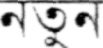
নতুন
